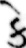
કે
